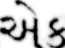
એક
